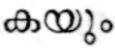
കയും
